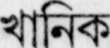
খানিক
